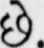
છે.
